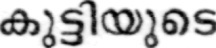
കുട്ടിയുടെ
